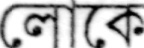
লোকে
